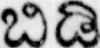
ಬಿಡಿ
